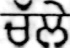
ਚੱਲੇ
